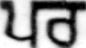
ਪਰ
